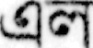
এল
